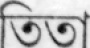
তিতা
